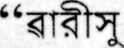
“ৱারীসু
